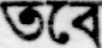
তবে
